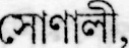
সোণালী,
